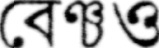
বেঞ্চও
